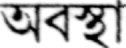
অবস্থা
